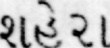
શહેરા
